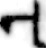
ન
